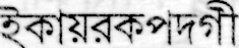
ইকায়রকপদগী
